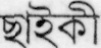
ছাইকী
